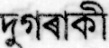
দুগৰাকী
